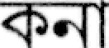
কনা
